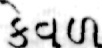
કેવળ
